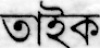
তাইক
